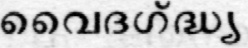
വൈദഗ്ദ്ധ്യ
